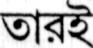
তারই
